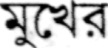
মুখের
